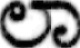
ಲಾ
